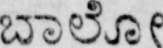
ಬಾಲೋ
